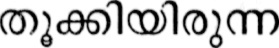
തൂക്കിയിരുന്ന
